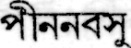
পীননবসু
